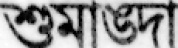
শুমাঙদা
